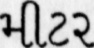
મીટર
